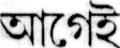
আগেই
